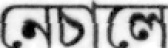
নেচালে
